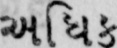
અધિક
